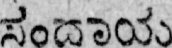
ಸಂದಾಯ
